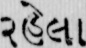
રહેલા
